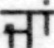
ਜਾਂ
